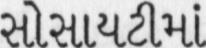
સોસાયટીમાં
